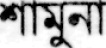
শামুনা
